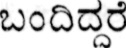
ಬಂದಿದ್ದರೆ
